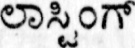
ಲಾಸ್ಟಿಂಗ್
